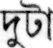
দুটা
